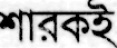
শারকই
